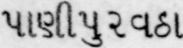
પાણીપુરવઠા
